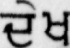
ਦੇਖ
